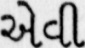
એવી
